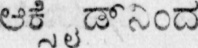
ಆಕ್ಸೈಡ್‌ನಿಂದ
